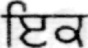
ਇਕ
